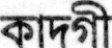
কাদগী
